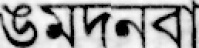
ঙমদনবা
